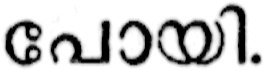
പോയി.
